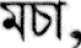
মচা,
